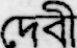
দেবী
